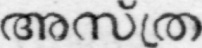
അസ്ത്ര
